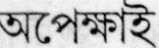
অপেক্ষাই
